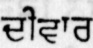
ਦੀਵਾਰ
